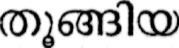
തൂങ്ങിയ
